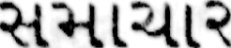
સમાચાર
